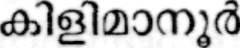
കിളിമാനൂര്‍
